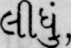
લીધું,
